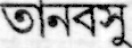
তানবসু
